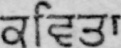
ਕਵਿਤਾ
